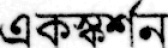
একস্কর্শন
